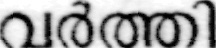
വര്‍ത്തി
